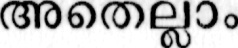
അതെല്ലാം
